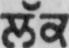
ਲੱਕ
